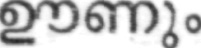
ഊണും
